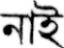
নাই
